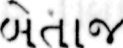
બેતાજ
